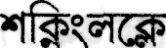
শক্নিংলক্লে
